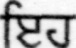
ਇਹ
